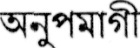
অনুপমাগী
